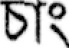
চাং
